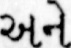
અને
